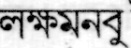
লক্ষমনসু
